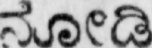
ನೋಡಿ
